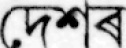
দেশৰ
